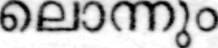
ലൊന്നും
